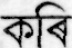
কৰি
